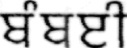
ਬੰਬਈ
